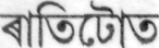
ৰাতিটোত
